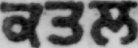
ਕਤਲ
